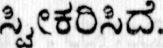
ಸ್ವೀಕರಿಸಿದೆ.
